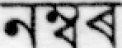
নম্বৰ
